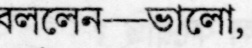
বললেন–ভালো,
